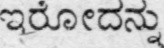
ಇರೋದನ್ನು
